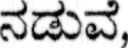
ನಡುವೆ,
